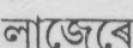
লাজেৰে
